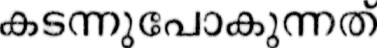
കടന്നുപോകുന്നത്
